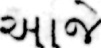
આજે
